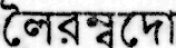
লৈরম্বদো
